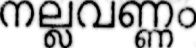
നല്ലവണ്ണം
